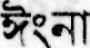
ঈংনা
